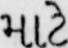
માટે
